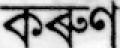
কৰুণ
